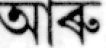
আৰু
